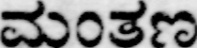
ಮಂತಣ
